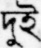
দুই
